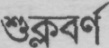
শুক্লবৰ্ণ
